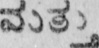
ಮತ್ತು
